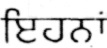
ਇਹਨਾਂ
